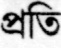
প্রতি
